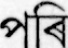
পৰি
